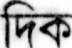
দিক
